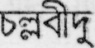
চল্লবীদু
